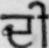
ਦੀ
